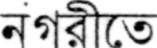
নগরীতে
